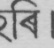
হৰি
